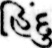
હિંદુ
